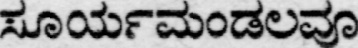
ಸೂರ್ಯಮಂಡಲವೂ
